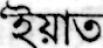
'ইয়াত
